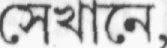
সেখানে,
